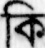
কি
